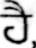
ਹੈ,
